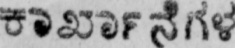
ಕಾರ್ಖಾನೆಗಳ
